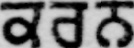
ਕਰਨ
